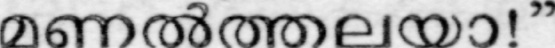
മണല്‍ത്തലയാ!"
